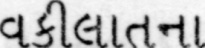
વકીલાતના
